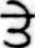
ਤੇ
